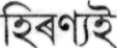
হিৰণ্যই
